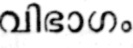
വിഭാഗം
